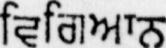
ਵਿਗਿਆਨ
